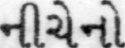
નીચેનો
